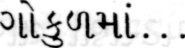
ગોકુળમાં..
